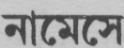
নামেসে
